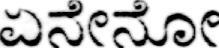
ಏನೇನೋ
